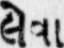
લેવા
